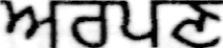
ਅਰਪਣ
